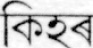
কিহৰ
